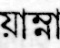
য়াম্না
